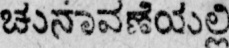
ಚುನಾವಣೆಯಲ್ಲಿ
